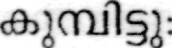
കുമ്പിട്ടു:
